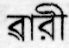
ৱারী
